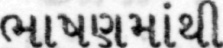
ભાષણમાંથી
